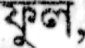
ফুল,
